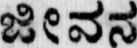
ಜೀವನ
